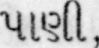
પાણી,
